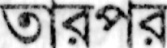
তারপর
